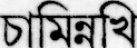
চামিন্নখি
